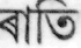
ৰাতি
